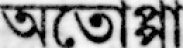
অতোপ্পা
